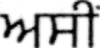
ਅਸੀਂ
